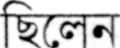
ছিলেন
